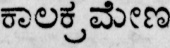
ಕಾಲಕ್ರಮೇಣ
